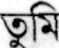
তুমি
